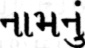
નામનું
